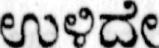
ಉಳಿದೇ
